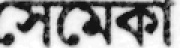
সেমেকা
